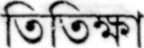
তিতিক্ষা
